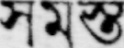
সমস্ত
